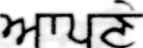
ਆਪਣੇ
